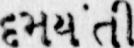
દમયંતી
